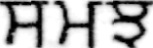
ਸਮਝ
